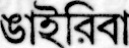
ঙাইরিবা
